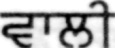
ਵਾਲੀ
